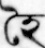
হৈ
